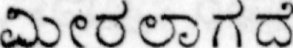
ಮೀರಲಾಗದೆ
